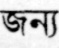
জন্য
